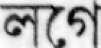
লগে
